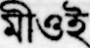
মীওই
